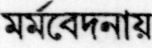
মর্মবেদনায়
